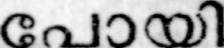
പോയി
